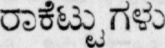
ರಾಕೆಟ್ಟುಗಳು
